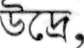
উদ্রে,
